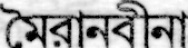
মৈরানবীনা
